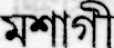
মশাগী
